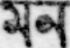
মন
